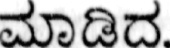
ಮಾಡಿದ.
